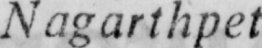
Nagarthpet
